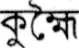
কুম্মৈ
